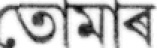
তোমাৰ
